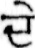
ਦੇ
